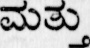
ಮತ್ತು
